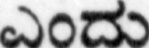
ಎಂದು
